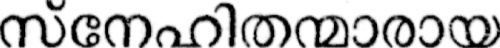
സ്നേഹിതന്മാരായ
